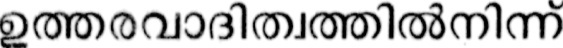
ഉത്തരവാദിത്വത്തില്‍നിന്ന്
